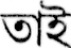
তাই
